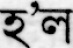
হ'ল
